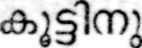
കൂട്ടിനു
